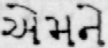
એમને
